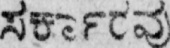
ಸರ್ಕಾರವು
